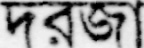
দরজা
